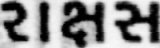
રાક્ષસ
